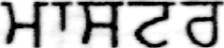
ਮਾਸਟਰ
